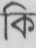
কি
